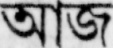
আজ
